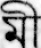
মী
